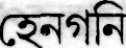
হেনগনি
